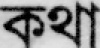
কথা
